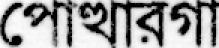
পোত্থারগা
